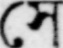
সে
